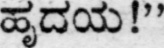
ಹೃದಯ!”
